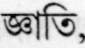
জ্ঞাতি,
